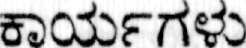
ಕಾರ್ಯಗಳು
